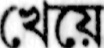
খেয়ে
